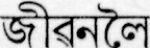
জীৱনলৈ
